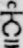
ਨੂੰ
